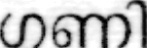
ഗണി
